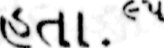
હતા.૯૫
